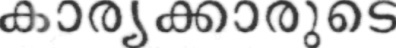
കാര്യക്കാരുടെ
